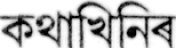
কথাখিনিৰ
